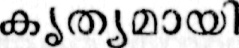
കൃത്യമായി
